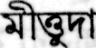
মীত্তুদা
